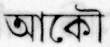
আকৌ
